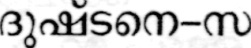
ദുഷ്ടനെ-സ
